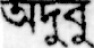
অদুবু
